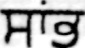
ਸਾਂਭ
